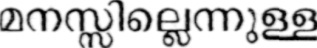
മനസ്സില്ലെന്നുള്ള
